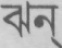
ঝন্
